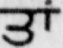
ਤਾਂ
